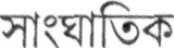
সাংঘাতিক
